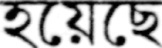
হয়েছে
